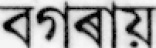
বগৰায়
